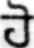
ਹੋ
